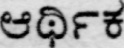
ಆರ್ಥಿಕ
